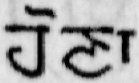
ਹੋਣਾ
